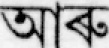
আৰু
